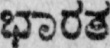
ಭಾರತ
